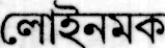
লোইনমক
